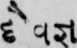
દૈવજ્ઞ
